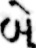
બે
